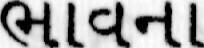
ભાવના
